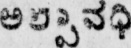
ಅಲ್ಪಾವಧಿ
